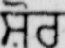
ਸ਼ੋਰ
